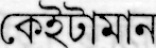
কেইটামান
